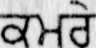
ਕਮਰੇ
